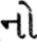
નો
